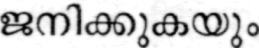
ജനിക്കുകയും
